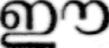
ഈ
